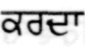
ਕਰਦਾ
